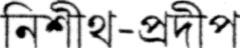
নিশীথ-প্রদীপ
